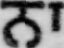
ਨਾ
